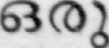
ഒരു
